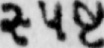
સ્પષ્ટ
